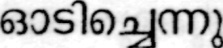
ഓടിച്ചെന്നു
